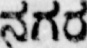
ನಗರ
